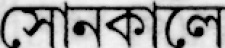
সোনকালে
